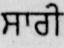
ਸਾਰੀ
